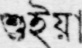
শুইয়া
